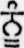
ਨੂੰ
